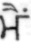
ਮੈਂ
